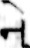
ને
